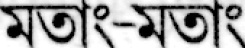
মতাং-মতাং
